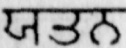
ਯਤਨ
